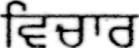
ਵਿਚਾਰ
